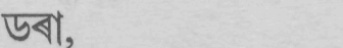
ডৰা,
